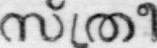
സ്ത്രീ
